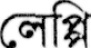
লেপ্পি
